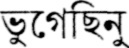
ভুগেছিনু
